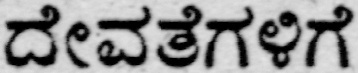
ದೇವತೆಗಳಿಗೆ
